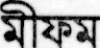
মীফম
